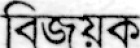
বিজয়ক
